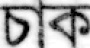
চাক
